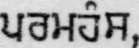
ਪਰਮਹੰਸ,
